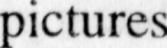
pictures
